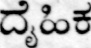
ದೈಹಿಕ
